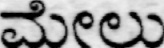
ಮೇಲು
